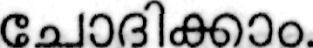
ചോദിക്കാം.
